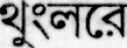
থুংলরে
